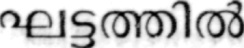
ഘട്ടത്തില്‍
